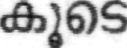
കൂടെ
